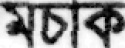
মচাক
